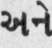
અને
